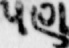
પણ
